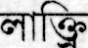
লাক্ত্রি
